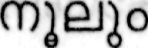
നൂലും
